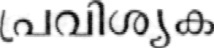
പ്രവിശ്യക
